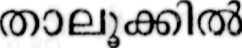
താലൂക്കില്‍
